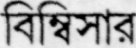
বিম্বিসার
